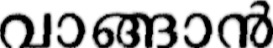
വാങ്ങാന്‍
